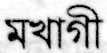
মখাগী
